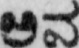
ಅವ
